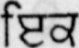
ਇਕ
